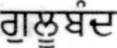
ਗੁਲੂਬੰਦ
